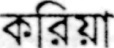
করিয়া
